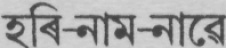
হৰি-নাম-নাৱে
